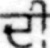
ਦੀ
